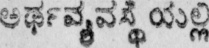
ಅರ್ಥವ್ಯವಸ್ಥೆಯಲ್ಲಿ
